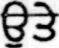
ਉਤੇ
